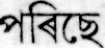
পৰিছে
